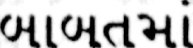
બાબતમાં
